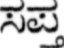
ಸಪ್ತ
